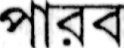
পারব
